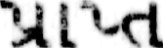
પ્રાપ્ત
